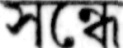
সন্ধে
